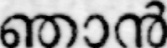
ഞാന്‍
